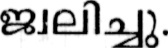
ജ്വലിച്ചു.
